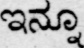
ಇನ್ನೂ
